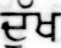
ਦੁੱਖ
